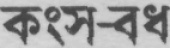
কংস-বধ
